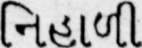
નિહાળી
